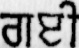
ਗਈ
